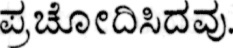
ಪ್ರಚೋದಿಸಿದವು.
